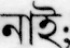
নাই;
